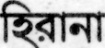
হিরানা
